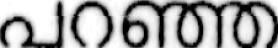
പറഞ്ഞ
